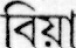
বিয়া
